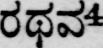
ರಥವ4
